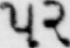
પર
